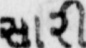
સારી
